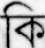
কি
